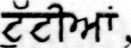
ਟੁੱਟੀਆਂ,
